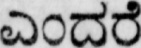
ಎಂದರೆ
